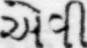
એવી
